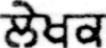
ਲੇਖਕ
